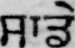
ਸਾਡੇ
